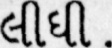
લીધી.
